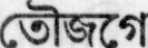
তৌজগে
